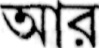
আর
